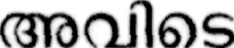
അവിടെ
